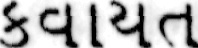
કવાયત
